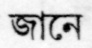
জানে
